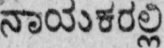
ನಾಯಕರಲ್ಲಿ
